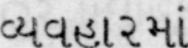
વ્યવહારમાં
